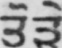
ਤੋੜੇ
